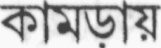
কামড়ায়
